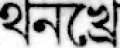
থনখ্রে
